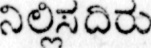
ನಿಲ್ಲಿಸದಿರು
